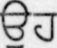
ਉਹ
